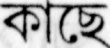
কাছে
